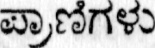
ಪ್ರಾಣಿಗಳು
